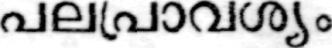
പലപ്രാവശ്യം
